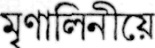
মৃণালিনীয়ে
